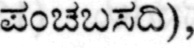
ಪಂಚಬಸದಿ),
